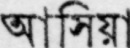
আসিয়া
